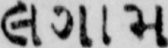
લગામ
